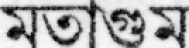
মতাগুম
